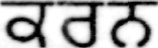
ਕਰਨ
